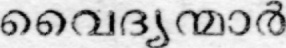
വൈദ്യന്മാര്‍
